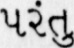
પરંતુ
